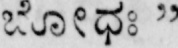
ಬೋಧಃ”
